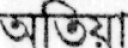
অতিয়া
